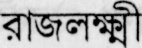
রাজলক্ষ্মী
